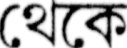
থেকে
